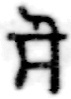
ਸੌ
